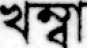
খম্বা
